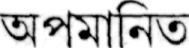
অপমানিত
